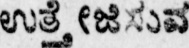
ಉತ್ತೇಜಿಸುವ
